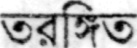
তরঙ্গিত
